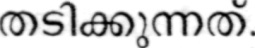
തടിക്കുന്നത്.
